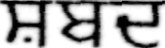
ਸ਼ਬਦ
